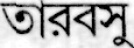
তারবসু
